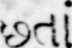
છતાં
